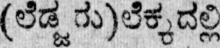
(ಲೆಡ್ಜರು)ಲೆಕ್ಕದಲ್ಲಿ
